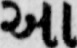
આ
